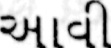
આવી
